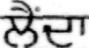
ਲੈਂਦਾ
